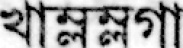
খাম্লম্লগা
